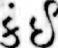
કંઈ
